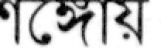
শঙ্গোয়
